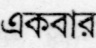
একবার
